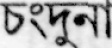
চংদুনা
